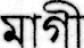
মাগী
